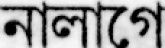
নালাগে
